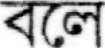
বলে
